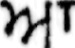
ਆ
